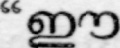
"ഈ
